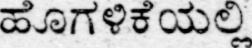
ಹೊಗಳಿಕೆಯಲ್ಲಿ
